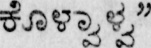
ಕೊಳ್ವಾಳ್ವ”
